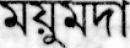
ময়ুমদা
